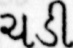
ચડી
